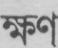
ক্ষণ
